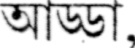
আড্ডা,
